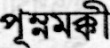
পূম্নমক্কী
